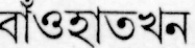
বাঁওহাতখন
